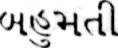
બહુમતી
